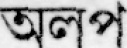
অলপ
